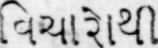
વિચારોથી
